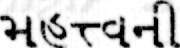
મહત્ત્વની
